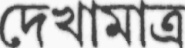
দেখামাত্র
